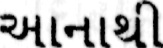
આનાથી
